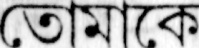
তোমাকে
